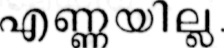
എണ്ണയില്ല.
